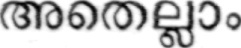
അതെല്ലാം
